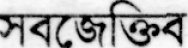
সবজেক্তিব
